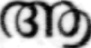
ആ
